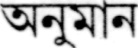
অনুমান
